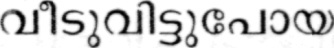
വീടുവിട്ടുപോയ
